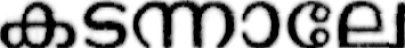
കടന്നാലേ
